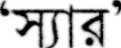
‘স্যার’
